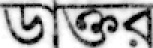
ডাক্তর
